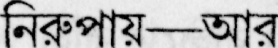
নিরুপায়-আর
